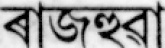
ৰাজহুৱা
